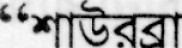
“শাউরব্রা
